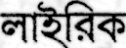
লাইরিক
